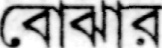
বোঝার
